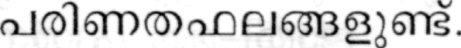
പരിണതഫലങ്ങളുണ്ട്.
